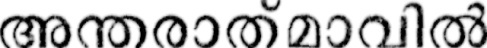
അന്തരാത്മാവില്‍
